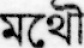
মথৌ
